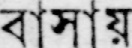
বাসায়
